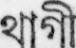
থাগী
